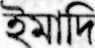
ইমাদি
